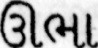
ઊભા
